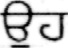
ਉਹ
